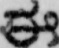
ಈ
